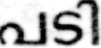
പടി
